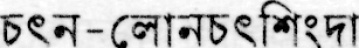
চৎন-লোনচৎশিংদা
